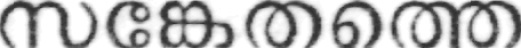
സങ്കേതത്തെ
